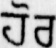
ਹੋਰ
